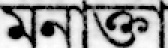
মনাক্তা
